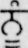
ਨੂੰ
